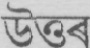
উত্তৰ
